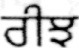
ਰੀਝ
